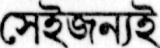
সেইজন্যই
